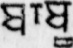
ਬਾਬੂ
